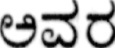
ಅವರ
